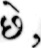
છે,
